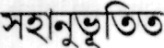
সহানুভূতিত
